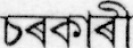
চৰকাৰী
